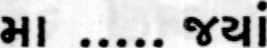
મા............જ્યાં
